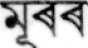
মূৰৰ
